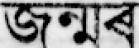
জন্মৰ
